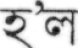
হ'ল
